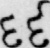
દર્દ
